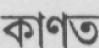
কাণত
